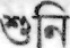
শুনি
